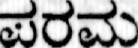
ಪರಮ
